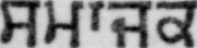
ਸਮਾਜਕ
